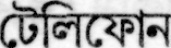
টেলিফোন
